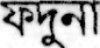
ফদুনা
